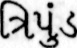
ત્રિપુંડ
